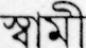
স্বামী
